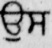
ਉਸ
